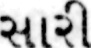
સારી
